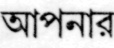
আপনার
